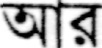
আর
